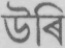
উৰি
